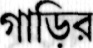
গাড়ির
